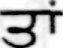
ਤਾਂ
